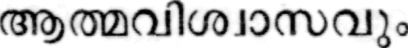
ആത്മവിശ്വാസവും
